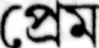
প্রেম
